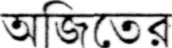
অজিতের
